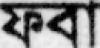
ফবা
